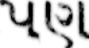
પણ
